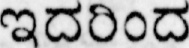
ಇದರಿಂದ
